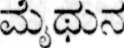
ಮೈಥುನ
